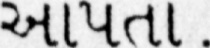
આપતા.
